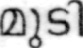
മുടി
